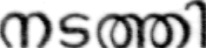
നടത്തി
